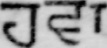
ਹਵਾ
